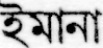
ইমানা
